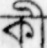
কী
